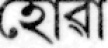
হোৱা
